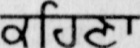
ਕਹਿਣਾ
